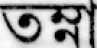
তম্না
